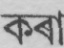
কৰা
